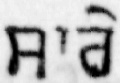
ਸਾਰੇ
